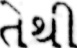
તેથી
